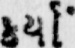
કર્યાં
